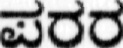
ಪರರ
